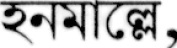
হনমাল্লে,
